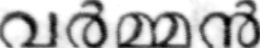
വര്‍മ്മന്‍
